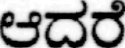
ಆದರೆ
